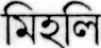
মিহলি
